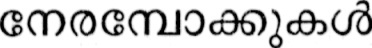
നേരമ്പോക്കുകള്‍
